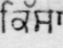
ਕਿੱਸਾ
